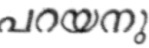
പറയനു
